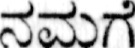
ನಮಗೆ
